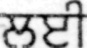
ਲਈ
